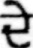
ਦੇ
